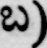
ಬ)
